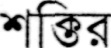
শক্তির
